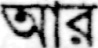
আর
